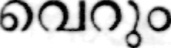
വെറും
